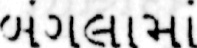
બંગલામાં
